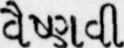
વૈષ્ણવી
